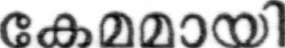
കേമമായി
